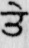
ਤੇ
